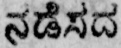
ನಡೆಸದ
